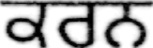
ਕਰਨ
